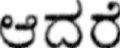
ಆದರೆ
